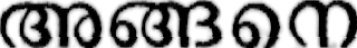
അങ്ങനെ
